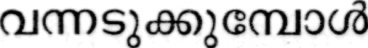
വന്നടുക്കുമ്പോള്‍
